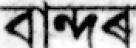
বান্দৰ
